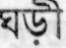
ঘড়ী
